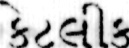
કેટલીક
